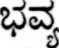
ಭವ್ಯ
